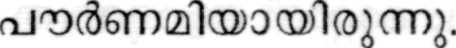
പൌര്‍ണമിയായിരുന്നു.
